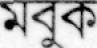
মবুক
